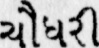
ચૌધરી
